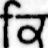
ਕਿ
